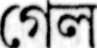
গেল
